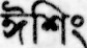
ঈশিং
